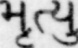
મૃત્યુ
